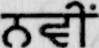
ਨਵੀਂ
